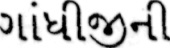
ગાંધીજીની
